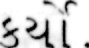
કર્યો.
